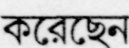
করেছেন
